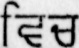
ਵਿਚ
